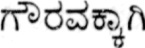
ಗೌರವಕ್ಕಾಗಿ
